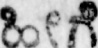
ಹೀಗೆ
